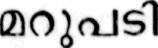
മറുപടി
